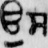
ਉਸ
